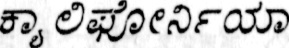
ಕ್ಯಾಲಿಫೋರ್ನಿಯಾ
